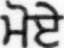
ਮੋਏ
